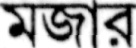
মজার
